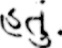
હતું.
